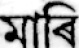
মাৰি
